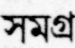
সমগ্র
